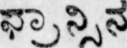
ಫ್ರಾನ್ಸಿನ
